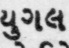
યુગલ
